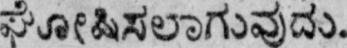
ಘೋಷಿಸಲಾಗುವುದು.
